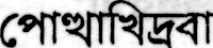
পোত্থাখিদ্রবা
